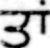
ਤਾਂ
